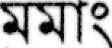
মমাং
